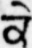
ਕੇ
